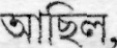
আছিল,
